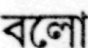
বলো
